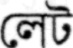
লেট
